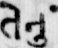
તેનું
